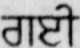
ਗਈ
